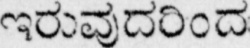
ಇರುವುದರಿಂದ
